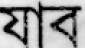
যাব
